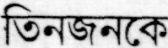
তিনজনকে
